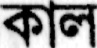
কাল
